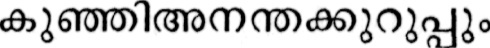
കുഞ്ഞിഅനന്തക്കുറുപ്പും
